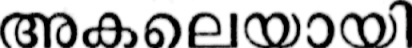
അകലെയായി
